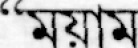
“ময়াম
